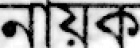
নায়ক
